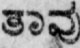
ತಾವು
